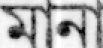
মানা
